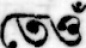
তেওঁ
